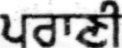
ਪਰਾਣੀ
